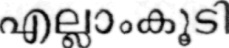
എല്ലാംകൂടി
